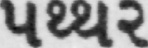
પથ્થર
